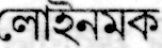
লোইনমক
